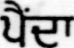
ਪੈਂਦਾ
